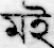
মই
